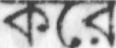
করে
